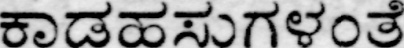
ಕಾಡಹಸುಗಳಂತೆ
